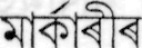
মাৰ্কাৰীৰ
